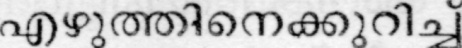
എഴുത്തിനെക്കുറിച്ച്
